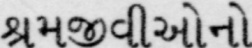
શ્રમજીવીઓનો
